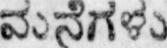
ಮನೆಗಳು
